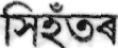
সিহঁতৰ
